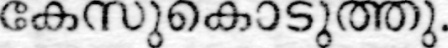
കേസുകൊടുത്തു.
